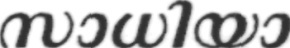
സാധിയാ
